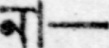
না—
